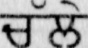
ਚੱਲੇ
